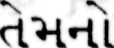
તેમનો
